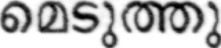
മെടുത്തു
